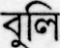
বুলি
